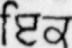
ਇਕ
